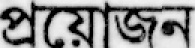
প্রয়োজন
